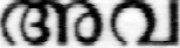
അവ
